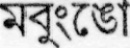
মবুংঙো
